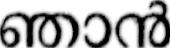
ഞാന്‍
